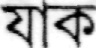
যাক
